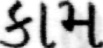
કામ
